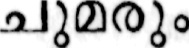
ചുമരും
